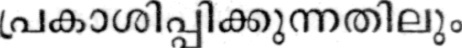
പ്രകാശിപ്പിക്കുന്നതിലും
